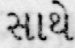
સાથે
